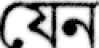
যেন
